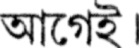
আগেই।
